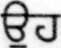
ਉਹ
